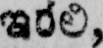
ಇರಲಿ,
